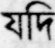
যদি
